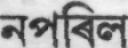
নপৰিল
